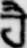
ਹੈ
